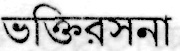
ভক্তিরসনা
